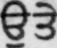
ਉਤੇ
